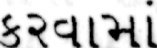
કરવામાં
